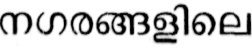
നഗരങ്ങളിലെ
